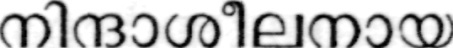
നിന്ദാശീലനായ
